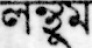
লন্থুম
